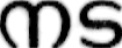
നട
